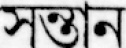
সন্তান
